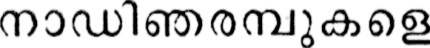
നാഡിഞരമ്പുകളെ
